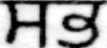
ਸਭ
